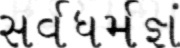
સર્વધર્મજ્ઞં
